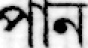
পান
